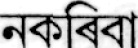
নকৰিবা
